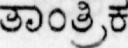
ತಾಂತ್ರಿಕ
